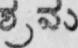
ಶ್ರಮ
